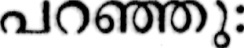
പറഞ്ഞു:
